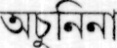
অচুনিনা
